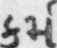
કર્મ
